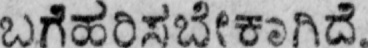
ಬಗೆಹರಿಸಬೇಕಾಗಿದೆ.
